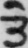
ਤੇ
